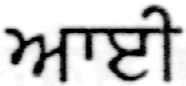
ਆਈ
